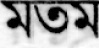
মতম
